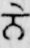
ਨੇ
